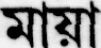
মায়া
